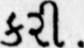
કરી.
